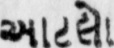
આટલો
